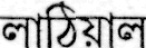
লাঠিয়াল
